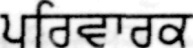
ਪਰਿਵਾਰਕ
